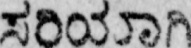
ಸರಿಯಾಗಿ
